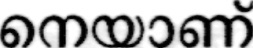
നെയാണ്
